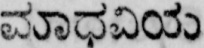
ಮಾಧವಿಯ
